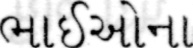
ભાઈઓના
